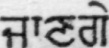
ਜਾਣਗੇ
